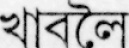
খাবলৈ
